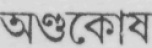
অণ্ডকোষ
